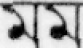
মম
